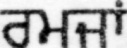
ਰਮਜਾਂ
